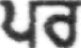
ਪਰ
